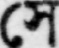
সে
